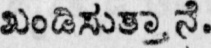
ಖಂಡಿಸುತ್ತಾನೆ.
